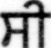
ਸੀ
